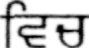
ਵਿਚ
